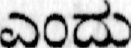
ಎಂದು
